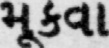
મૂકવા
